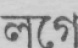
লগে
